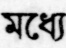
মধ্যে
